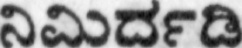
ನಿಮಿರ್ದಡಿ
